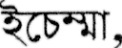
ইচেম্মা,
